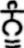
ਨੂੰ
